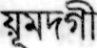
য়ূমদগী
